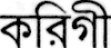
করিগী
